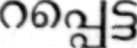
റപ്പെട്ട
